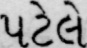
પટેલે
